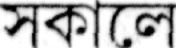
সকালে
